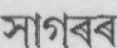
সাগৰৰ
